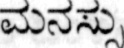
ಮನಸ್ಸು
